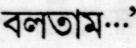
বলতাম...’
